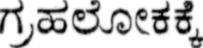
ಗ್ರಹಲೋಕಕ್ಕೆ
